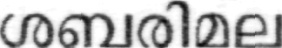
ശബരിമല
